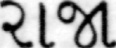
રાજા
